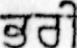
ਭਰੀ
